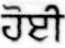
ਹੋਈ
